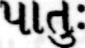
પાતુઃ
